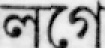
লগে
